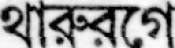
থারুরগে
